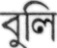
বুলি
